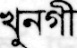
খুনগী
